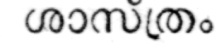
ശാസ്ത്രം
